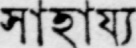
সাহায্য
